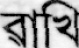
ৱাখি
